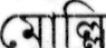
মোল্লি
